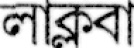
লাক্লবা
